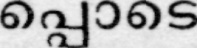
പ്പൊടെ
